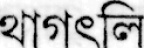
থাগৎলি
